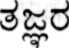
ತಜ್ಞರ
